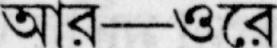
আর-ওরে
